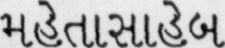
મહેતાસાહેબ
